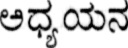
ಅಧ್ಯಯನ
